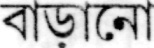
বাড়ানো
